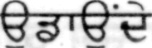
ਉਡਾਉਂਦੇ
